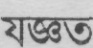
যজ্ঞত
